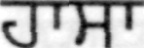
ਹਾਸਾ
